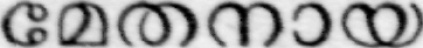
മേതനായ
